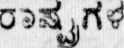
ರಾಷ್ಟ್ರಗಳ
